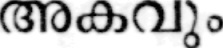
അകവും
